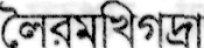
লৈরমখিগদ্রা
